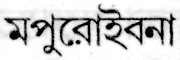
মপুরোইবনা
